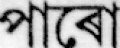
পাৰো
